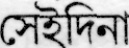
সেইদিনা
